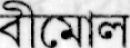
বীমোল
